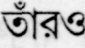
তাঁরও
